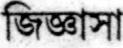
জিজ্ঞাসা
